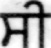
ਸੀ
